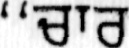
''ਚਾਰ
